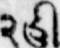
રહી
